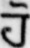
ਹੋ
